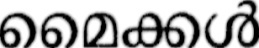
മൈക്കള്‍
